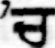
'ਚ
